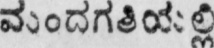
ಮಂದಗತಿಯಲ್ಲಿ
